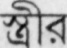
স্ত্রীর
